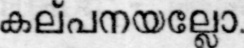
കല്പനയല്ലോ.
